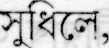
সুধিলে,
